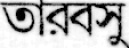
তারবসু
